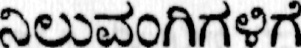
ನಿಲುವಂಗಿಗಳಿಗೆ
